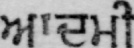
ਆਦਮੀ
